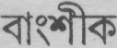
বাংশীক
